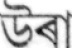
উৰা
